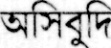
অসিবুদি
